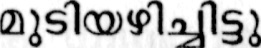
മുടിയഴിച്ചിട്ടു
